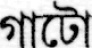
গাটো
